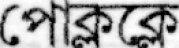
পোক্লক্লে
